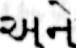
અને
